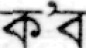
ক'ব
